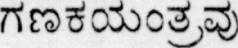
ಗಣಕಯಂತ್ರವು
